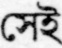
সেই
